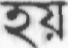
হয়
